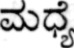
ಮಧ್ಯೆ
